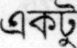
একটু
